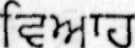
ਵਿਆਹ
